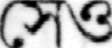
সেও
